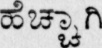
ಹೆಚ್ಚಾಗಿ
